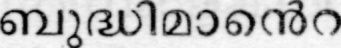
ബുദ്ധിമാന്റെ
